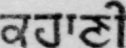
ਕਹਾਣੀ
